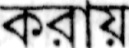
করায়
